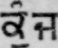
ਕੁੰਜ
